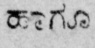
ಹಾಗೂ
